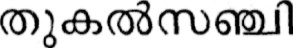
തുകല്‍സഞ്ചി
